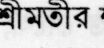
শ্রীমতীর
